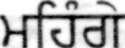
ਮਹਿੰਗੇ
